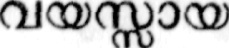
വയസ്സായ
